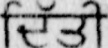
ਦਿੱਤੀ
